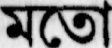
মতো
